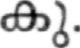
കു.
